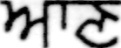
ਆਣ
